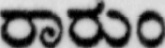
ರಾರುಂ
